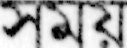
সময়
